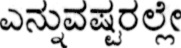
ಎನ್ನುವಷ್ಟರಲ್ಲೇ
